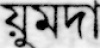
য়ুমদা
